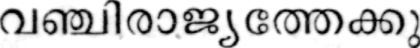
വഞ്ചിരാജ്യത്തേക്കു
